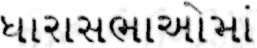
ધારાસભાઓમાં
